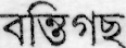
বন্তিগছ
